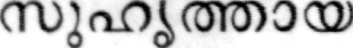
സുഹൃത്തായ
